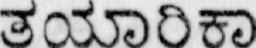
ತಯಾರಿಕಾ
